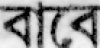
বাবে
